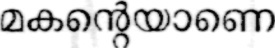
മകന്റെയാണെ
